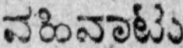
ವಹಿವಾಟು
